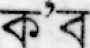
ক'ব
